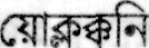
য়োক্লক্কনি
